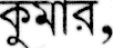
কুমার,
